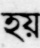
হয়
